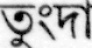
তুংদা
